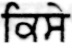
ਕਿਸੇ
